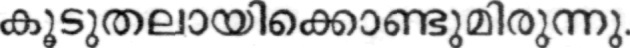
കൂടുതലായിക്കൊണ്ടുമിരുന്നു.
